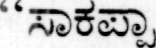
“ಸಾಕಪ್ಪಾ
